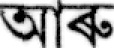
আৰু
